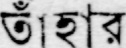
তাঁহার
